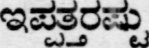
ಇಪ್ಪತ್ತರಷ್ಟು
